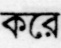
করে
